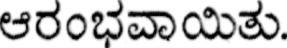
ಆರಂಭವಾಯಿತು.
